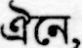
ঐনে,
